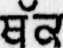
ਥੱਕ
